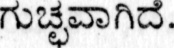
ಗುಚ್ಛವಾಗಿದೆ.
